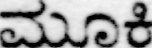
ಮೂಕಿ
